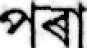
পৰা
